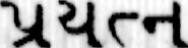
પ્રયત્ન
